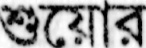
শুয়োর
